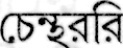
চেন্থররি
